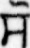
ਸੋ
